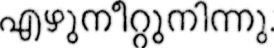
എഴുനീറ്റുനിന്നു.
